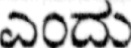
ಎಂದು
